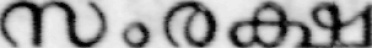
സംരക്ഷ
